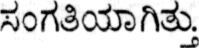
ಸಂಗತಿಯಾಗಿತ್ತು.
